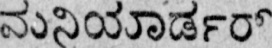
ಮನಿಯಾರ್ಡರ್
